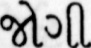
જોગી
